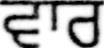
ਵਾਰ
